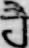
ਹੈ
